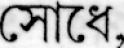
সোধে,
